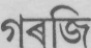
গৰজি
